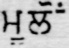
ਮੂਲੋਂ
